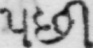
પછી
